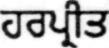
ਹਰਪ੍ਰੀਤ
